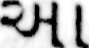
આ
